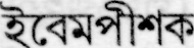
ইবেমপীশক
